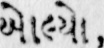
બોલ્યો,
